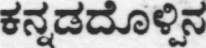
ಕನ್ನಡದೊಳ್ಪಿನ
